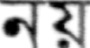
নয়
